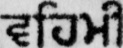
ਵਹਿਮੀ
